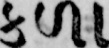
કળા
